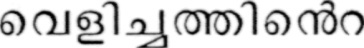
വെളിച്ചത്തിന്റെ
